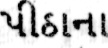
પીઠાના
